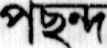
পছন্দ
